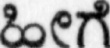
ಹೀಗೆ
